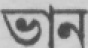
ভান
